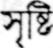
সৃষ্টি
